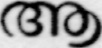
ആ
